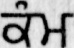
ਕੰਮ
